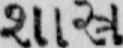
શાસ્ત્ર
